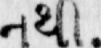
નથી.
